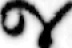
જ
